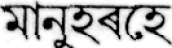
মানুহৰহে
